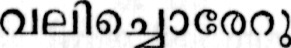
വലിച്ചൊരേറു
